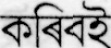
কৰিবই
